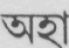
অহা
